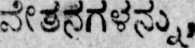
ವೇತನಗಳನ್ನು,
